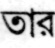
তার
